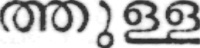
ത്തുള്ള
